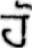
ਹੋ
